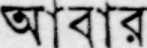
আবার
